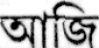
আজি
